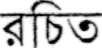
রচিত
